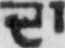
ਦਾ
